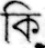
কি
